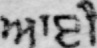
ਆਈ
